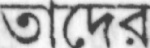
তাদের
